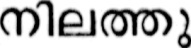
നിലത്തു
